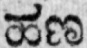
ಹಣ
